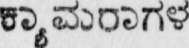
ಕ್ಯಾಮರಾಗಳ
